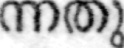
ന്നതു
